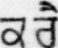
ਕਰੈ
